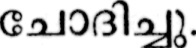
ചോദിച്ചു.
